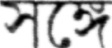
সঙ্গে
